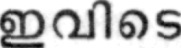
ഇവിടെ
